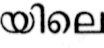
യിലെ
